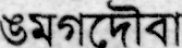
ঙমগদৌবা
